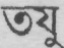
তযু
